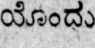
ಯೊಂದು
